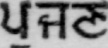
ਪੁਜਣ
